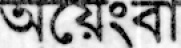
অয়েংবা
